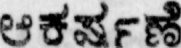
ಆಕರ್ಷಣೆ
